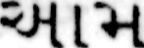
આમ
